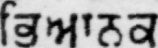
ਭਿਆਨਕ
